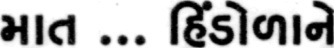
માત...હિંડોળાને
